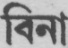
বিনা
